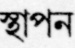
স্থাপন
